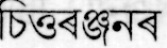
চিত্তৰঞ্জনৰ
